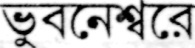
ভুবনেশ্বরে
